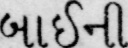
બાઈની
